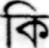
কি
